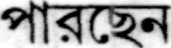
পারছেন
